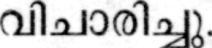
വിചാരിച്ചു.
